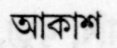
আকাশ
